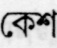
কেশ
